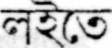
লইতে
